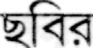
ছবির
